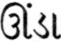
ઊંડા
